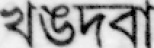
খঙদবা
